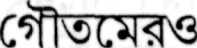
গৌতমেরও
